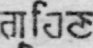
ਗ੍ਰਹਿਣ
